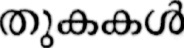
തുകകള്‍
